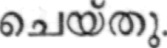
ചെയ്തു.
